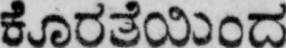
ಕೊರತೆಯಿಂದ
